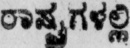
ರಾಷ್ಟ್ರಗಳಲ್ಲಿ
